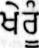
ਖੇਰੂੰ
